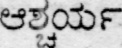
ಆಶ್ಚರ್ಯ
